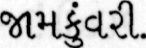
જામકુંવરી.
